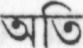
অতি
